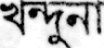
খন্দুনা
